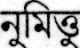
নুমিত্তু
